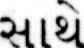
સાથે
